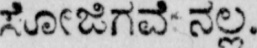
ಸೋಜಿಗವೇನಲ್ಲ.
